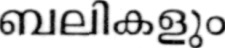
ബലികളും
